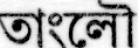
তাংলৌ
